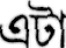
এটা
